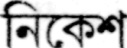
নিকেশ
